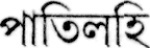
পাতিলহি
